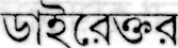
ডাইরেক্তর
